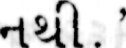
નથી.
